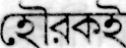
হৌরকই
